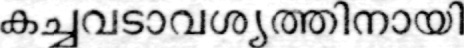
കച്ചവടാവശ്യത്തിനായി
